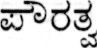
ಪೌರತ್ವ
